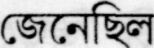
জেনেছিল
